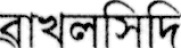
ৱাখলসিদি
